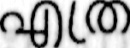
എത്ര
